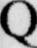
Q
